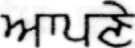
ਆਪਣੇ
